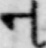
ન
